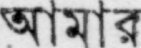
আমার
